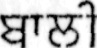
ਬਾਲੀ
